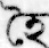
হৈ
